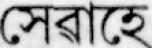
সেৱাহে
